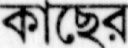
কাছের
